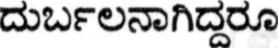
ದುರ್ಬಲನಾಗಿದ್ದರೂ
